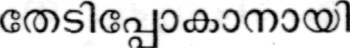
തേടിപ്പോകാനായി
